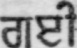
ਗਈ
